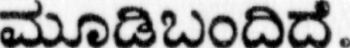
ಮೂಡಿಬಂದಿದೆ.
